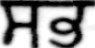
ਸਭ
